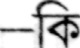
-কি
